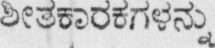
ಶೀತಕಾರಕಗಳನ್ನು
